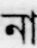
না
